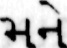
મને
